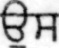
ਉਸ
